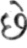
છે
